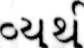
વ્યર્થ
